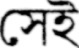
সেই
